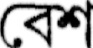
বেশ
